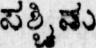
ಪಶ್ಚಿಮ
